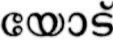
യോട്
